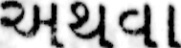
અથવા
